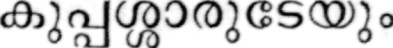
കുപ്പശ്ശാരുടേയും
